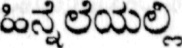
ಹಿನ್ನೆಲೆಯಲ್ಲಿ
